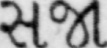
સજા
